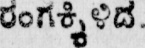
ರಂಗಕ್ಕಿಳಿದ.
